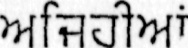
ਅਜਿਹੀਆਂ
